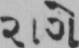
રાગે
